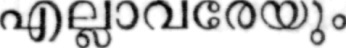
എല്ലാവരേയും
